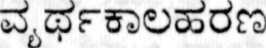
ವ್ಯರ್ಥಕಾಲಹರಣ
